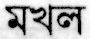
মখল
